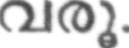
വരൂ.
